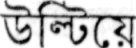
উল্টিয়ে
